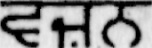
ਵਜ਼ਨ
